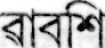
ৱাবশি
